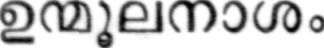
ഉന്മൂലനാശം
